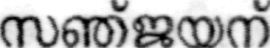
സഞ്ജയന്
